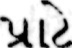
પ્રાટે
